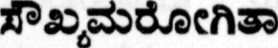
ಸೌಖ್ಯಮರೋಗಿತಾ
